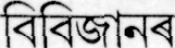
বিবিজানৰ
